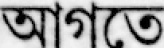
আগতে
